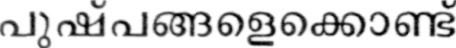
പുഷ്പങ്ങളെക്കൊണ്ട്
